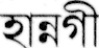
হান্নগী
